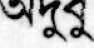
অদুবু
